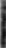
I
